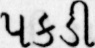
પકડી
